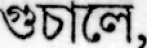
গুচালে,
